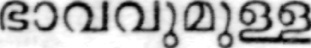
ഭാവവുമുള്ള
